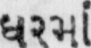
ધરમાં
